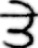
ਤੇ
